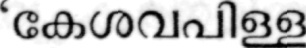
'കേശവപിള്ള
